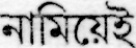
নামিয়েই
